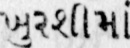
ખુરશીમાં
